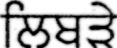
ਲਿਬੜੇ
